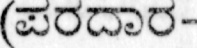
(ಪರದಾರ-
